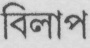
বিলাপ
